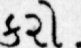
કરો.
